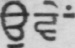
ਉਵੇਂ
